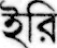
ইরি
